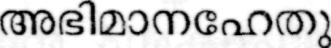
അഭിമാനഹേതു
